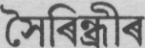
সৈৰিন্ধ্ৰীৰ
